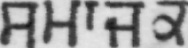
ਸਮਾਜਕ
